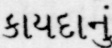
કાયદાનું
